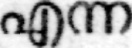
എന്ന
